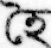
হৈ
